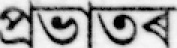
প্রভাতৰ
